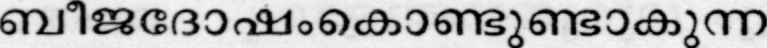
ബീജദോഷംകൊണ്ടുണ്ടാകുന്ന
